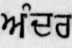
ਅੰਦਰ
